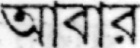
আবার
